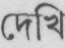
দেখি
